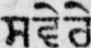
ਸਵੇਰੇ
